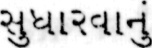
સુધારવાનું
